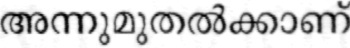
അന്നുമുതല്‍ക്കാണ്
